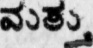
ಮತ್ತು
